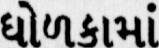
ધોળકામાં
